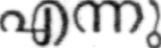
എന്നു
